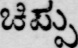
ಚಿಪ್ಪು
